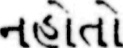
નહોતો
